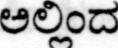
ಅಲ್ಲಿಂದ
